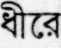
ধীরে
